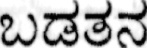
ಬಡತನ
